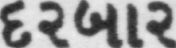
દરબાર
